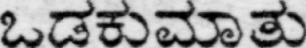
ಒಡಕುಮಾತು
